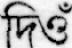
দিওঁ
